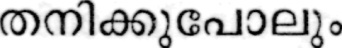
തനിക്കുപോലും
